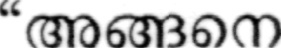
“അങ്ങനെ
